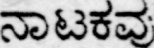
ನಾಟಕವು
